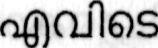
എവിടെ
